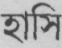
হাসি
